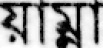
য়াম্না
